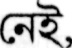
নেই,
